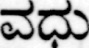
ವಧು
